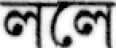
ললে
